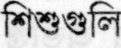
শিশুগুলি
